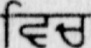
ਵਿਚ
